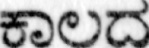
ಕಾಲದ
